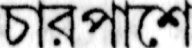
চারপাশে
